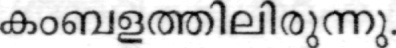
കംബളത്തിലിരുന്നു.
